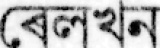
ৰেলখন
